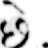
છે.
